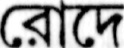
রোদে
